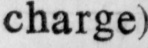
Charge)
